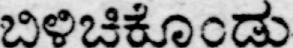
ಬಿಳಿಚಿಕೊಂಡು
